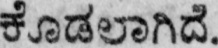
ಕೊಡಲಾಗಿದೆ.
